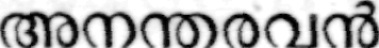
അനന്തരവന്‍
